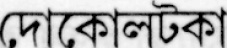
দোকোলটকা
